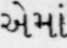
એમાં
